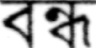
বন্ধ
